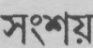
সংশয়
